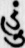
હું
